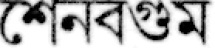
শেনবগুম
